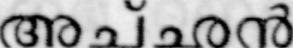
അച്ഛന്‍
